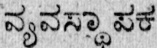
ವ್ಯವಸ್ಥಾಪಕ
